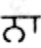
ਨਾ
